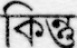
কিন্তু
